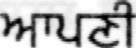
ਆਪਣੀ
